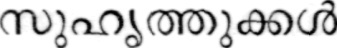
സുഹൃത്തുക്കള്‍
